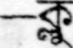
-ক্লু
